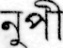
নুপী
